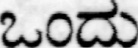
ಒಂದು
